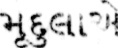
મૃદુલાએ
